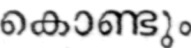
കൊണ്ടും
